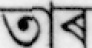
তাৰ
